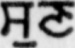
ਸੁਣ
